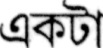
একটা
